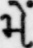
મેં
